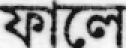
ফালে
